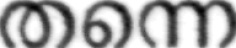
തന്നെ
